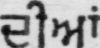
ਦੀਆਂ
